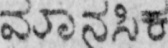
ಮಾನಸಿಕ
